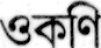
ওকণি
